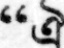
“ঐ
